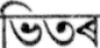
ভিতৰ
